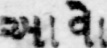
આવો
